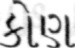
કોણ
